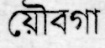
য়ৌবগা
